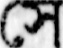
সে
